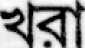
খরা
